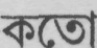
কতো
